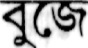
বুজে
